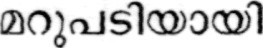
മറുപടിയായി
